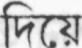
দিয়ে
